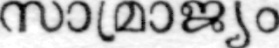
സാമ്രാജ്യം
